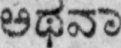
ಅಥವಾ
